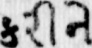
કરીને
